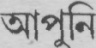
আপুনি
